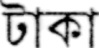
টাকা
